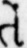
તેં
